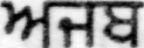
ਅਜਬ
